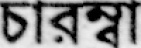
চারম্বা
